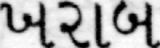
ખરાબ
